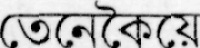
তেনেকৈয়ে
